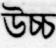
উচ্চ
